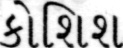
કોશિશ
